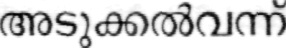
അടുക്കല്‍വന്ന്
